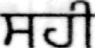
ਸਹੀ
